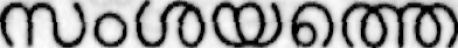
സംശയത്തെ
